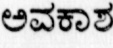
ಅವಕಾಶ
